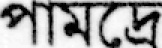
পামদ্রে
